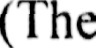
(The
